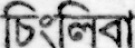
চিংলিবা
